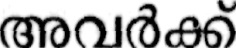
അവര്‍ക്ക്
